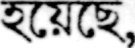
হয়েছে,
